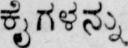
ಕೈಗಳನ್ನು
